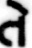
તે
